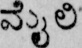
ಮೈಲಿ
